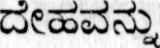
ದೇಹವನ್ನು
